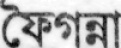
ফৈগন্না
